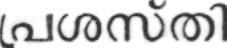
പ്രശസ്തി
